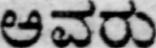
ಅವರು
